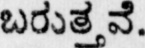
ಬರುತ್ತವೆ.
